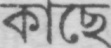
কাছে
